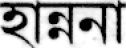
হান্ননা
